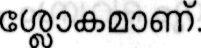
ശ്ലോകമാണ്.
